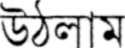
উঠলাম
